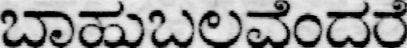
ಬಾಹುಬಲವೆ೦ದರೆ
